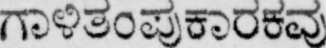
ಗಾಳಿತಂಪುಕಾರಕವು
